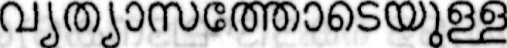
വ്യത്യാസത്തോടെയുള്ള
